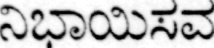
ನಿಭಾಯಿಸವ
